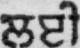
ਲਈ
